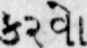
કરવો
